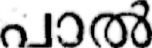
പാല്‍
